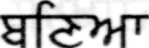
ਬਣਿਆ
